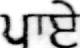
ਪਾਏ
